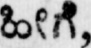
ಹೀಗೆ,
